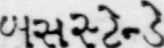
બસસ્ટેન્ડે
